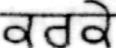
ਕਰਕੇ
